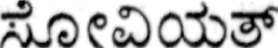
ಸೋವಿಯತ್
